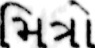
મિત્રો
